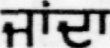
ਜਾਂਦਾ
